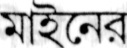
মাইনের
